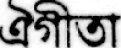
ঐগীতা
